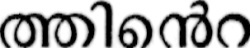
ത്തിന്റെ
